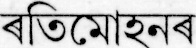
ৰতিমোহনৰ
